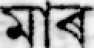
মাৰ
